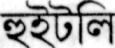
হুইটলি
